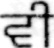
ਵੀ
